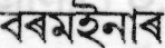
বৰমইনাৰ
